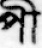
পী
